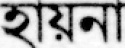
হায়না
